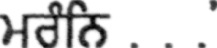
ਮਰੰਨਿ
